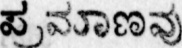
ಪ್ರಮಾಣವು
